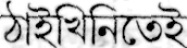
ঠাইখিনিতেই
